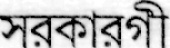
সরকারগী
